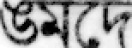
ঙমদে
